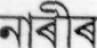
নাৰীৰ
